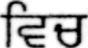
ਵਿਚ
